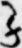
કે
